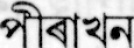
পীৰাখন
